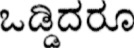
ಒಡ್ಡಿದರೂ
